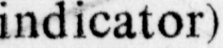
Indicator)
